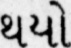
થયો
